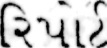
રિપોર્ટ
